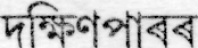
দক্ষিণপাৰৰ
